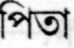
পিতা
